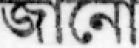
জানো
